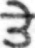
ਤੇ
